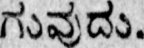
ಗುವುದು.
